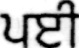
ਪਈ
